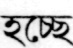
হচ্ছে
